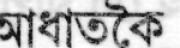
আধাতকৈ
